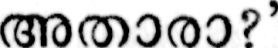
അതാരാ?’
